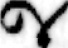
જ
